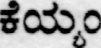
ಕೆಯ್ಯಂ
